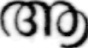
ആ
